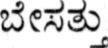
ಬೇಸತ್ತು
